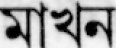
মাখন
